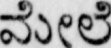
ಮೇಲೆ
